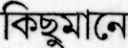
কিছুমানে
